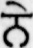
ਨੇ
